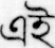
এই
